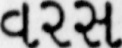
વરસ
